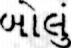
બોલું
